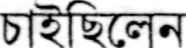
চাইছিলেন
